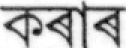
কৰাৰ
